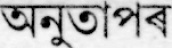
অনুতাপৰ
